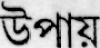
উপায়
